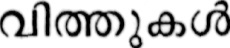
വിത്തുകള്‍
